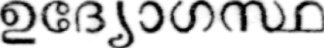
ഉദ്യോഗസ്ഥ
